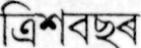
ত্রিশবছৰ
